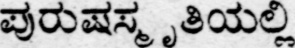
ಪುರುಷಸ್ಮೃತಿಯಲ್ಲಿ
